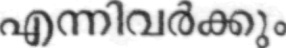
എന്നിവര്‍ക്കും
